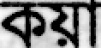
কয়া
